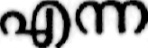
എന്ന
